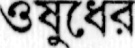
ওষুধের
